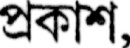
প্রকাশ,
